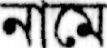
নামে
